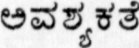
ಅವಶ್ಯಕತೆ
